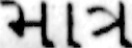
માત્ર
